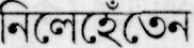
নিলেহেঁতেন
